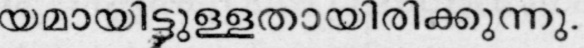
യമായിട്ടുള്ളതായിരിക്കുന്നു.
